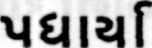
પધાર્યા
